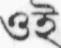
ওই
